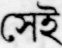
সেই
